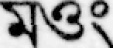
মওং
